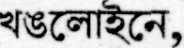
খঙলোইনে,
